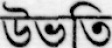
উভতি
